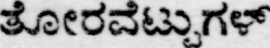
ತೋರವೆಟ್ಟುಗಳ್
